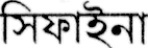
সিফাইনা
